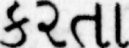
કરતા
